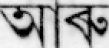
আৰু
